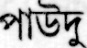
পাউদু
